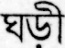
ঘড়ী
